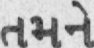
તમને
